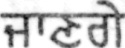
ਜਾਣਗੇ
